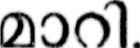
മാറി.
